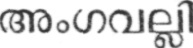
അംഗവല്ലി
